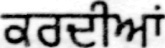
ਕਰਦੀਆਂ
